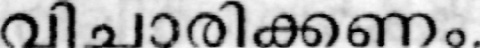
വിചാരിക്കണം.
